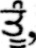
ਤੂੰ,
